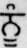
ਨੂੰ
